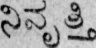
ನಿವೃತ್ತಿ
